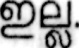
ഇല്ല.
